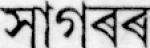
সাগৰৰ
